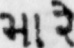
મારે
